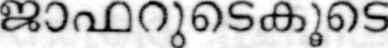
ജാഫറുടെകൂടെ
